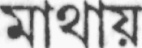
মাথায়
